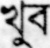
খুব
